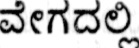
ವೇಗದಲ್ಲಿ
